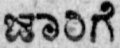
ಜಾರಿಗೆ
